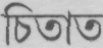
চিতাত
